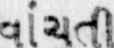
વાંચતી
